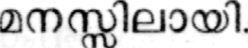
മനസ്സിലായി.
